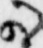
જે
